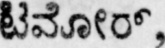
ಟಿಮೋರ್,
